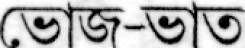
ভোজ-ভাত
